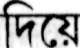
দিয়ে
